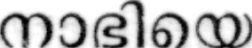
നാഭിയെ
